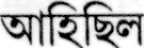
আহিছিল
